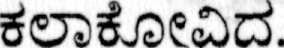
ಕಲಾಕೋವಿದ.
